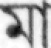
মা
